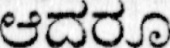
ಆದರೂ
